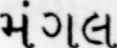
મંગલ
